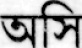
অসি
